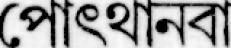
পোৎথানবা
